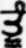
ਤੂੰ
